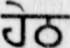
ਹੇਠ
